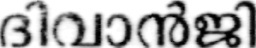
ദിവാന്‍ജി
